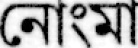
নোংমা
